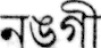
নঙগী
